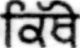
ਕਿੱਥੇ
